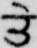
ਤੇ
